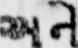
અને
